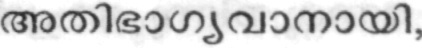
അതിഭാഗ്യവാനായി,
